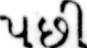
પછી
